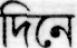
দিনে
